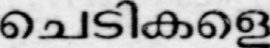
ചെടികളെ
